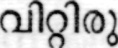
വിറ്റിരു
